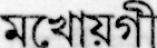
মখোয়গী
